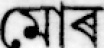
মোৰ
